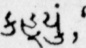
કહ્યું,
